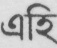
এহি
